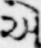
એ
